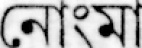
নোংমা
